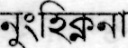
নুংহিক্ননা
